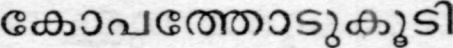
കോപത്തോടുകൂടി
